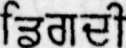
ਡਿਗਦੀ
